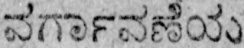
ವರ್ಗಾವಣೆಯ
